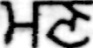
ਮਣ
